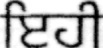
ਇਹੀ
